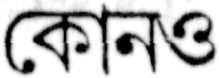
কোনও
